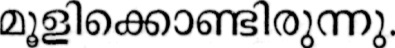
മൂളിക്കൊണ്ടിരുന്നു.
